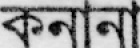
কনানা
